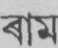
ৰাম
